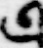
এ
